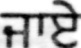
ਜਾਏ
